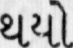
થયો
